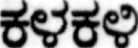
ಕಳಕಳಿ
